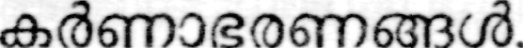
കര്‍ണാഭരണങ്ങള്‍.
